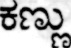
ಕಣ್ಣು
